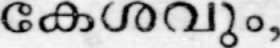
കേശവും,
